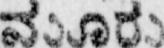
ಮೂರು
